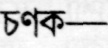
চণক–
